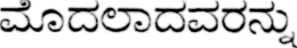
ಮೊದಲಾದವರನ್ನು
